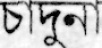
চাদুনা
